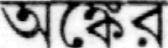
অঙ্কের
